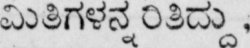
ಮಿತಿಗಳನ್ನರಿತಿದ್ದು,
